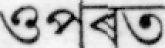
ওপৰত
